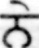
ਨੇ
